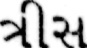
ત્રીસ
